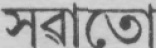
সৱাতো
